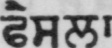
ਫੈਸਲਾ
